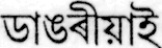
ডাঙৰীয়াই
